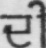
ਦੀ
